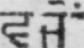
ਵਜੋਂ
